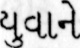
યુવાને
